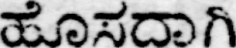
ಹೊಸದಾಗಿ
